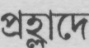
প্ৰহ্লাদে
